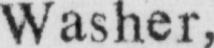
Washer,
